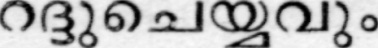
റദ്ദുചെയ്യവും
